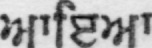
ਆਇਆ
